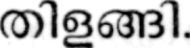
തിളങ്ങി.
